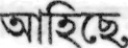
আহিছে,
